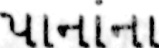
પાનાંના
